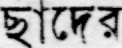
ছাদের
